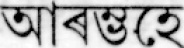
আৰম্ভহে
